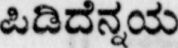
ಪಿಡಿದೆನ್ನಯ
